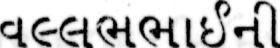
વલ્લભભાઈની
